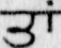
ਤਾਂ
